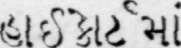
હાઈકોર્ટમાં
